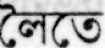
লৈতে
